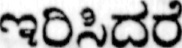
ಇರಿಸಿದರೆ
